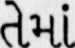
તેમાં
